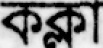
কক্লা
